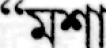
“মশা
